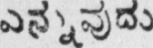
ಎನ್ನುವುದು
